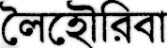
লৈহৌরিবা
